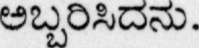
ಅಬ್ಬರಿಸಿದನು.
